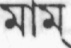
মাম্
